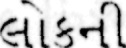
લોકની
